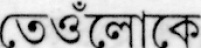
তেওঁলোকে
